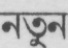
নতুন
